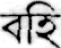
বহি
